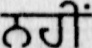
ਨਹੀਂ
